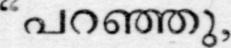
"പറഞ്ഞു,
